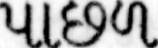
પાછળ
